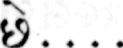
છે....
